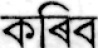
কৰিব
